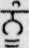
ਨੂੰ
